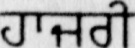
ਹਾਜਰੀ
